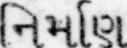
નિર્માણ
